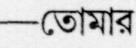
–তোমার
